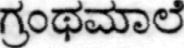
ಗ್ರಂಥಮಾಲೆ
